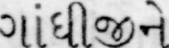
ગાંધીજીને
